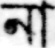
না
